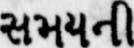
સમયની
